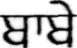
ਬਾਬੇ
